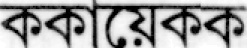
ককায়েকক
